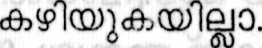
കഴിയുകയില്ലാ.
